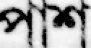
পাশ
